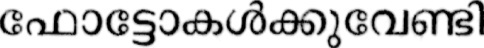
ഫോട്ടോകള്‍ക്കുവേണ്ടി
